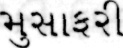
મુસાફરી
